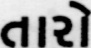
તારો
